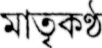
মাতৃকণ্ঠ
